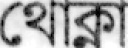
থোক্না
